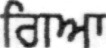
ਗਿਆ
